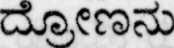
ದ್ರೋಣನು
